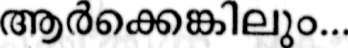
ആര്‍ക്കെങ്കിലും…
